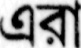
এরা
